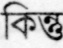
কিন্তু
